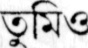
তুমিও
